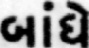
બાંધે
